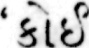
'કોઈ
